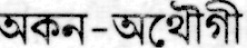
অকন-অথৌগী
